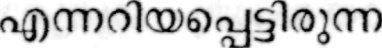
എന്നറിയപ്പെട്ടിരുന്ന
